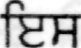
ਇਸ
